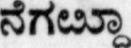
ನೆಗೞ್ದಾ
